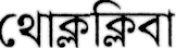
থোক্লক্লিবা
